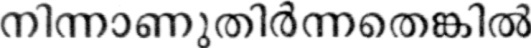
നിന്നാണുതിര്‍ന്നതെങ്കില്‍
